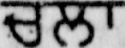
ਚਲਾ
